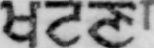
ਖਟਣਾ
